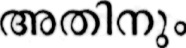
അതിനും
